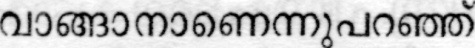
വാങ്ങാനാണെന്നുപറഞ്ഞ്
